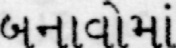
બનાવોમાં
